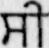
ਸੀ
